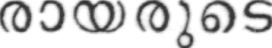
രായരുടെ
